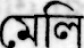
মেলি
